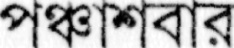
পঞ্চাশবার
